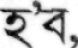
হ'ব,
